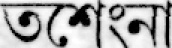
তশেংনা
